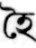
হৈ
